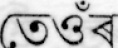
তেওঁৰ
